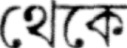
থেকে
